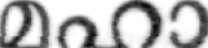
മഹാ
